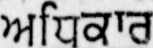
ਅਧਿਕਾਰ
